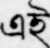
এই
